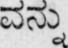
ವನ್ನು
